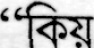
"কিয়
